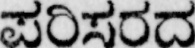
ಪರಿಸರದ
